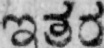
ಇತರ
